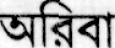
অরিবা
